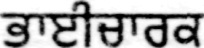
ਭਾਈਚਾਰਕ
